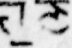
ਹੁਣ
